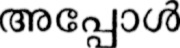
അപ്പോള്‍
